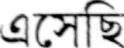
এসেছি
